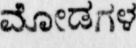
ಮೋಡಗಳ
